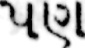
પણ
